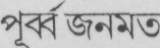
পূৰ্ব্বজনমত
